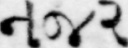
નજર
